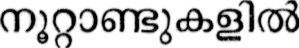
നൂറ്റാണ്ടുകളില്‍
